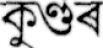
কুণ্ডৰ
